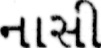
નાસી
